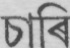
চাৰি
